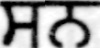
ਸਨ
